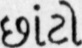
છાંટો
